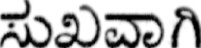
ಸುಖವಾಗಿ
